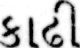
કાઢી
